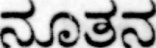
ನೂತನ
